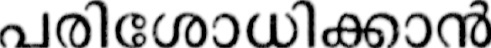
പരിശോധിക്കാന്‍
